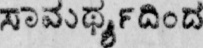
ಸಾಮರ್ಥ್ಯದಿಂದ
